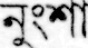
নুংশা
